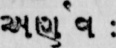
અર્ણવઃ
